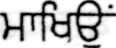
ਮਾਖਿਉਂ
